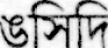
ঙসিদি
